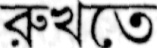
রুখতে
